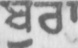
ਬੁਰਾ
